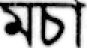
মচা
